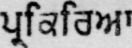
ਪ੍ਰਕਿਰਿਆ
